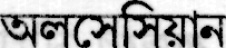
অলসেসিয়ান
